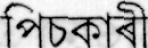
পিচকাৰী
